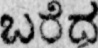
ಬರೆದ
